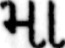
મા
